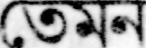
তেমন
